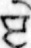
ਏ
